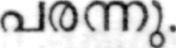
പരന്നു.
